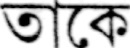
তাকে
